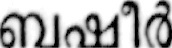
ബഷീര്‍
